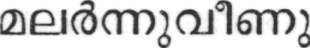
മലര്‍ന്നുവീണു
